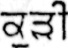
ਕੁੜੀ
